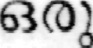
ഒരു
